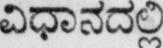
ವಿಧಾನದಲ್ಲಿ
